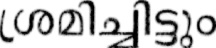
ശ്രമിച്ചിട്ടും
